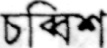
চব্বিশ
